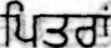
ਪਿਤਰਾਂ
